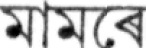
মামৰে
